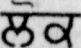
ਲੋਕ
